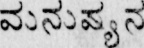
ಮನುಷ್ಯನ
